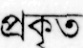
প্রকৃত
